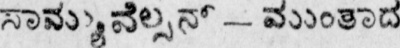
ಸಾಮ್ಯುವೆಲ್ಲನ್-ಮುಂತಾದ
